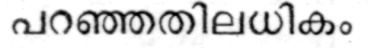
പറഞ്ഞതിലധികം
